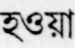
হওয়া
